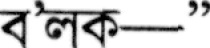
ব'লক-"
